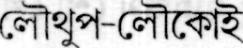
লৌথুপ-লৌকোই
